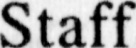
Staff
